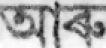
আৰু
